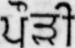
ਪੌੜੀ
